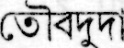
তৌবদুদা
